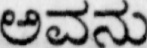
ಅವನು
